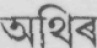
অথিৰ
